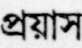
প্রয়াস
